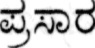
ಪ್ರಸಾರ
